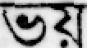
ভয়
